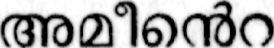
അമീന്റെ
